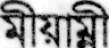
মীয়াম্নী
